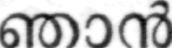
ഞാന്‍
